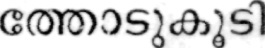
ത്തോടുകൂടി
